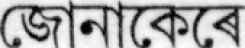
জোনাকেৰে
